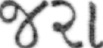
જરા
